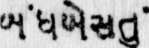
બંધબેસતું
